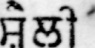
ਸ਼ੈਲੀ
